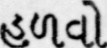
હળવો
